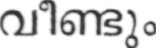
വീണ്ടും
